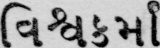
વિશ્વકર્મા
